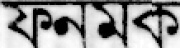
ফনমক
